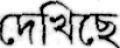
দেখিছে
